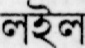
লইল
